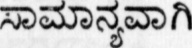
ಸಾಮಾನ್ಯವಾಗಿ
